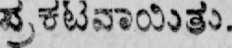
ಪ್ರಕಟವಾಯಿತು.
